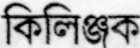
কিলিঞ্জক
